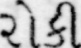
રોકી
